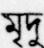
মৃদু
